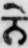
ਨੇ
